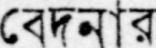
বেদনার
